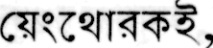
য়েথোরকই,
